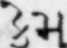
કેમ
